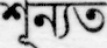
শূন্যত
